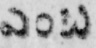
ಎಂಬ
